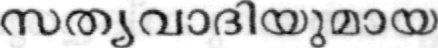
സത്യവാദിയുമായ
